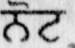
ਨੋਟ
